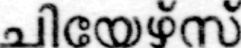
ചിയേഴ്സ്
